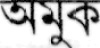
অমুক
